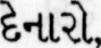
દેનારો,
